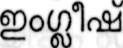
ഇംഗ്ലീഷ്
